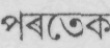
পৰতেক
